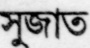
সুজাত
